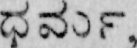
ಧರ್ಮ,
